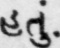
હતું.
